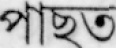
পাছত
